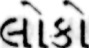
લોકો
